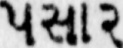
પસાર
